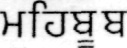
ਮਹਿਬੂਬ
